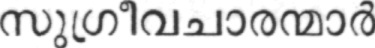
സുഗ്രീവചാരന്മാര്‍
